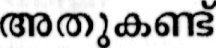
അതുകണ്ട്
